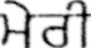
ਮੇਰੀ
